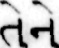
તેને
